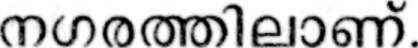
നഗരത്തിലാണ്.
